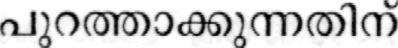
പുറത്താക്കുന്നതിന്
